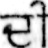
ਦੀ
